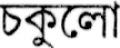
চকুলো
